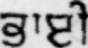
ਭਾਈ
